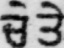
ਚੇਤੇ
